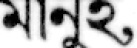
মানুহ,
